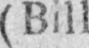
(Bill
